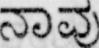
ನಾವು
